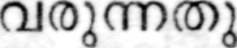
വരുന്നതു
